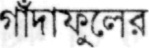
গাঁদাফুলের
